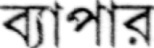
ব্যাপার
